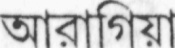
আরাগিয়া
